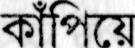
কাঁপিয়ে
